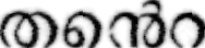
തന്റെ
